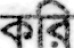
করি
